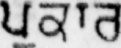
ਪੁਕਾਰ
